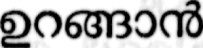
ഉറങ്ങാന്‍
